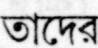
তাদের
